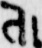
તો
